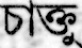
চাক্তু
